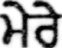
ਮੇਰੇ
